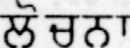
ਲੋਚਨਾ
